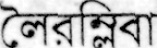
লৈরম্লিবা
